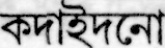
কদাইদনো
